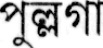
পুল্লগা
